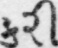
કરી
